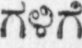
ಗಳಿಗೆ
